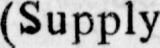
(Supply
